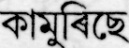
কামুৰিছে
